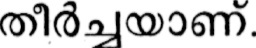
തീര്‍ച്ചയാണ്.
